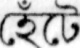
হেঁটে
